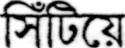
সিঁটিয়ে
